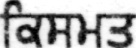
ਕਿਸਮਤ
